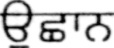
ਉਛਾਨ
